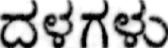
ದಳಗಳು
